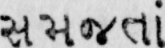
સમજતાં
